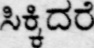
ಸಿಕ್ಕಿದರೆ
